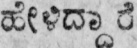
ಹೇಳಿದ್ದಾರೆ
